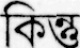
কিন্তু
